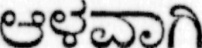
ಆಳವಾಗಿ
